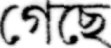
গেছে
